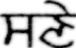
ਸਣੇ
